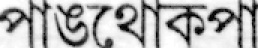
পাঙথোকপা
